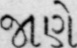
જાણે
